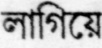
লাগিয়ে
